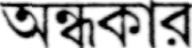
অন্ধকার
